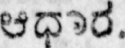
ಆಧಾರ.
